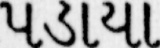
પડાયા
